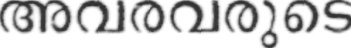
അവരവരുടെ
